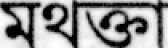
মথক্তা
